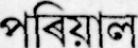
পৰিয়াল
